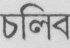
চলিব
